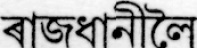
ৰাজধানীলৈ
